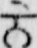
ਨੇ
